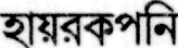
হায়রকপনি
